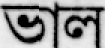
ভাল
